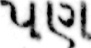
પણ
